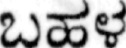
ಬಹಳ
